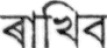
ৰাখিব
